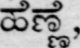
ಹೆಣ್ಣೆ,
